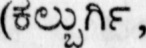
(ಕಲ್ಬುರ್ಗಿ,
